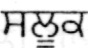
ਸਲੂਕ
